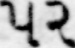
પર
